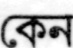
কেন
